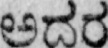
ಅದರ
